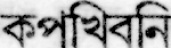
কপখিবনি
